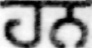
ਹਨ
